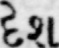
દેશ
